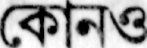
কোনও
